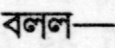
বলল–
